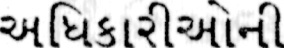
અધિકારીઓની
